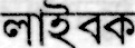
লাইবক
